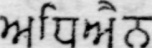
ਅਧਿਐਨ
